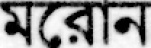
মরোন
